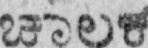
ಚಾಲಕ
